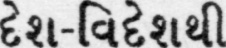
દેશ-વિદેશથી
